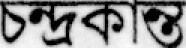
চন্দ্রকান্ত
